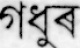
গধুৰ
